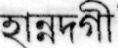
হান্নদগী
